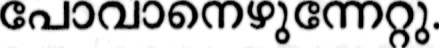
പോവാനെഴുന്നേറ്റു.
